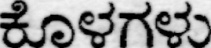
ಕೊಳಗಳು
